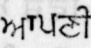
ਆਪਣੀ
